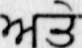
ਅਤੇ
